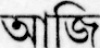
আজি
